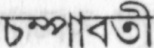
চম্পাবতী
